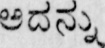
ಅದನ್ನು
